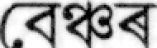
বেঞ্চৰ
